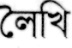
লৈখি
